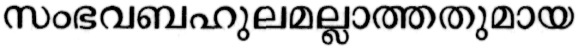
സംഭവബഹുലമല്ലാത്തതുമായ
